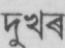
দুখৰ
